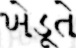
ખેડૂતે
